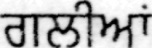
ਗਲੀਆਂ
